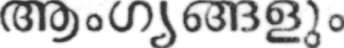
ആംഗ്യങ്ങളും
